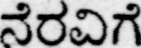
ನೆರವಿಗೆ
